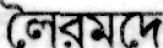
লৈরমদে
